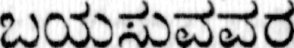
ಬಯಸುವವರ
